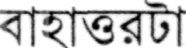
বাহাত্তরটা
